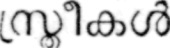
സ്ത്രീകള്‍
